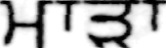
ਮਾੜਾ
